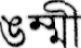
ঙম্মী
